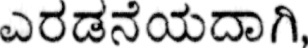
ಎರಡನೆಯದಾಗಿ,
